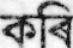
কৰি
